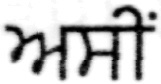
ਅਸੀਂ
